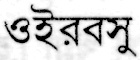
ওইরবসু
